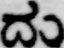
ದು
